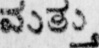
ಮತ್ತು
